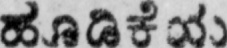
ಹೂಡಿಕೆಯ
